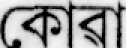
কোৱা
